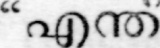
"എന്ത്
